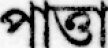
পাত্তা
